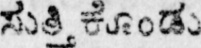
ಸುತ್ತಿಕೊಂಡು
